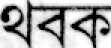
থবক
